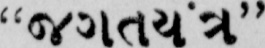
“જગતયંત્ર”
